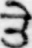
ਤੇ
